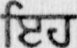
ਇਹ
